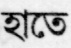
হাতে
